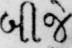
બીજે
